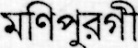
মণিপুরগী
